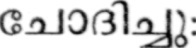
ചോദിച്ചു:
